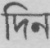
দিন
